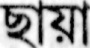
ছায়া
